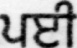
ਪਈ
